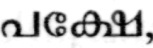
പക്ഷേ,
